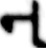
ન
